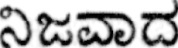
ನಿಜವಾದ
